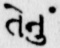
તેનું
